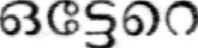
ഒട്ടേറെ
